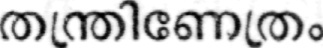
തന്ത്രിണേത്രം
